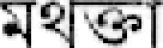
মথক্তা
